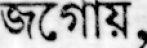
জগোয়,
